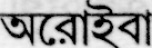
অরোইবা
